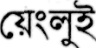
য়েংলুই
